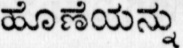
ಹೊಣೆಯನ್ನು
